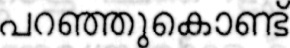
പറഞ്ഞുകൊണ്ട്
